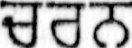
ਚਰਨ
